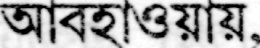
আবহাওয়ায়,
